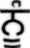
ਨੂੰ
